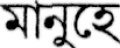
মানুহে
